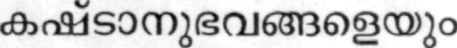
കഷ്ടാനുഭവങ്ങളെയും
